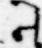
ને
